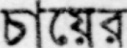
চায়ের
